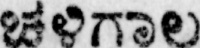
ಚಳಿಗಾಲ
